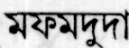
মফমদুদা
